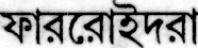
ফাররোইদরা
